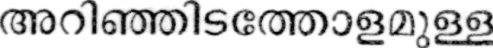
അറിഞ്ഞിടത്തോളമുള്ള
